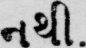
નથી.
